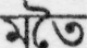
মতৈ
